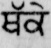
ਥੱਕੇ
